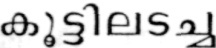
കൂട്ടിലടച്ച
